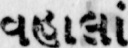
વહાલાં
